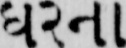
ઘરના
